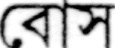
বোস
